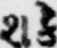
શકે
